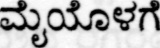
ಮೈಯೊಳಗೆ
